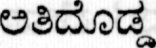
ಅತಿದೊಡ್ಡ
